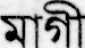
মাগী
